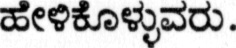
ಹೇಳಿಕೊಳ್ಳುವರು.
